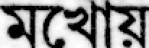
মখোয়
